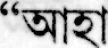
"আহা
